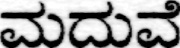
ಮದುವೆ
